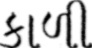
કાળી
